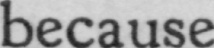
because
